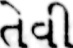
તેવી
